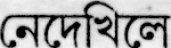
নেদেখিলে
